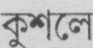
কুশলে
